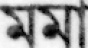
মমা
